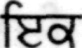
ਇਕ
